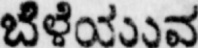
ಬೆಳೆಯುವ
